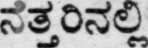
ನೆತ್ತರಿನಲ್ಲಿ
